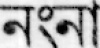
নংনা
